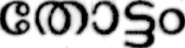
തോട്ടം
